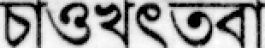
চাওখৎতবা
